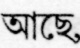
আছে,
